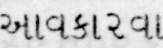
આવકારવા
